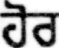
ਹੋਰ
